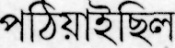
পঠিয়াইছিল
